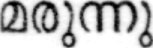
മരുന്നു
